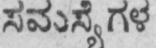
ಸಮಸ್ಯೆಗಳ
